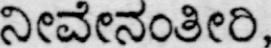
ನೀವೇನಂತೀರಿ,
